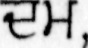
ਦਮ,
